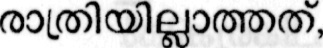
രാത്രിയില്ലാത്തത്,
